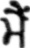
ਮੈਂ
